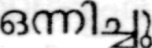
ഒന്നിച്ചു
